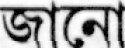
জানো
